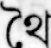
থৈ
